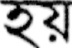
হয়
